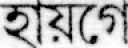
হায়গে
